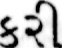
કરી
